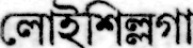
লোইশিল্লগা
